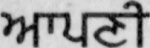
ਆਪਣੀ
